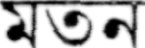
মতন
